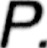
P.
